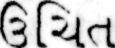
ઉચિત
